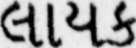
લાયક
